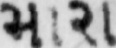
મારા
